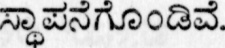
ಸ್ಥಾಪನೆಗೊಂಡಿವೆ.
